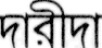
দারীদা
